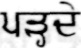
ਪੜ੍ਹਦੇ
